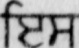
ਇਸ
